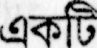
একটি
